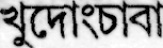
খুদোংচাবা
